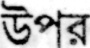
উপর
